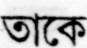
তাকে
